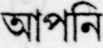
আপনি
